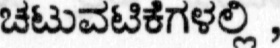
ಚಟುವಟಿಕೆಗಳಲ್ಲಿ,
